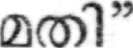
മതി”
